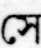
সে
